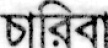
চারিবা
